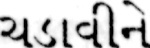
ચડાવીને
